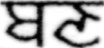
ਬਣ
